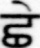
ਛੇ
